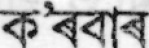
ক'ৰবাৰ
